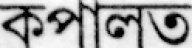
কপালত
